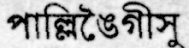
পাল্লিঙৈগীসু
